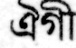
ঐগী
